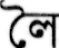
লৈ
